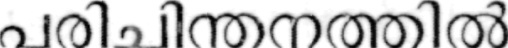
പരിചിന്തനത്തില്‍
